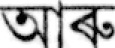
আৰু
